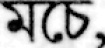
মচে,
